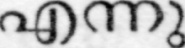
എന്നു
